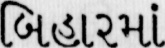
બિહારમાં
